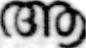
ആ
